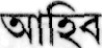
আহিব
